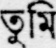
তুমি
